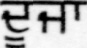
ਦੂਜਾ
